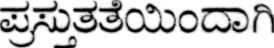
ಪ್ರಸ್ತುತತೆಯಿಂದಾಗಿ
